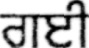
ਗਈ
